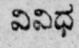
ವಿವಿಧ
